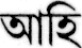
আহি
